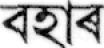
বহাৰ
